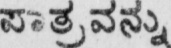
ಪಾತ್ರವನ್ನು
